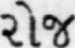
રોજ
